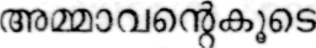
അമ്മാവന്റെകൂടെ
